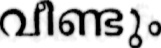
വീണ്ടും
